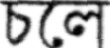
চলে
